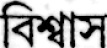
বিশ্বাস
